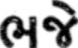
ભજે
